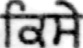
ਕਿਸੇ
